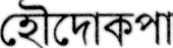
হৌদোকপা
